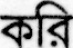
করি
